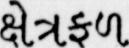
ક્ષેત્રફળ
